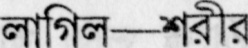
লাগিল-শরীর
